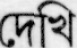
দেখি
